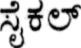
ಸೈಕಲ್
